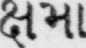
ક્ષમા
